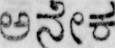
ಅನೇಕ
